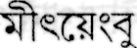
মীৎয়েংবু
